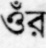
ওঁর
